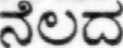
ನೆಲದ
